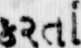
કરતાં
